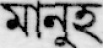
মানুহ
